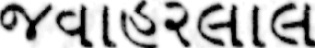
જવાહરલાલ
